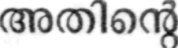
അതിന്റെ
